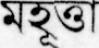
মহূত্তা
